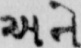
અને
